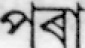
পৰা
